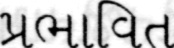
પ્રભાવિત
